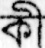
কী
